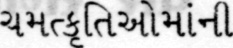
ચમત્કૃતિઓમાંની
